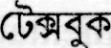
টেক্সবুক
